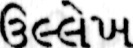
ઉલ્લેખ
